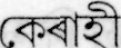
কেৰাহী
